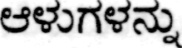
ಆಳುಗಳನ್ನು
